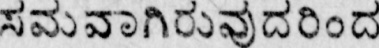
ಸಮವಾಗಿರುವುದರಿಂದ
